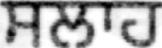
ਸਲਾਹ
